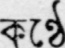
কণ্ঠে
